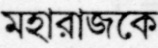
মহারাজকে
